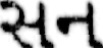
સન
